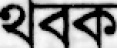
থবক
